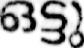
ഒട്ടു
